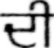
ਦੀ
